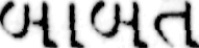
બાબત
